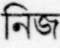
নিজ
